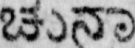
ಚುನಾ
